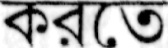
করতে
